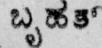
ಬೃಹತ್
